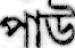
পাউ
